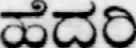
ಹೆದರಿ
